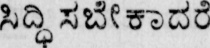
ಸಿದ್ಧಿಸಬೇಕಾದರೆ
